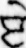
ਏ
